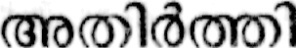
അതിര്‍ത്തി
